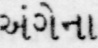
અંગેના
